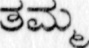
ತಮ್ಮ
